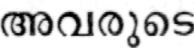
അവരുടെ
